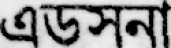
এডসনা
